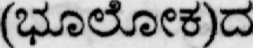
(ಭೂಲೋಕ)ದ
